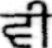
ਵੀ
